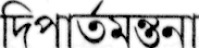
দিপার্তমন্তনা
